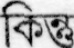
কিন্তু
